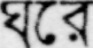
ঘরে
